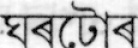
ঘৰটোৰ
